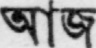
আজ
